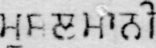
ਮੁਸਲਮਾਨੀ
